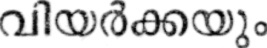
വിയര്‍ക്കയും
